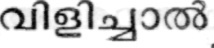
വിളിച്ചാല്‍
